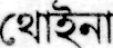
থোইনা
